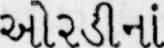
ઓરડીનાં
